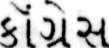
કોંગ્રેસ
